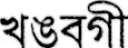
খঙবগী
